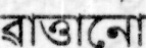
ৱাত্তানো
